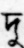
দু
